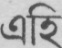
এহি
